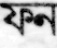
ফন
